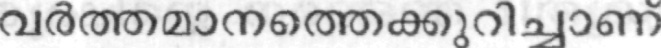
വര്‍ത്തമാനത്തെക്കുറിച്ചാണ്
